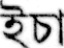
ইচা
